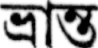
ভ্রান্ত
